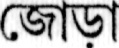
জোড়া
